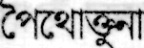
পৈথোক্তুনা
